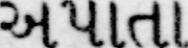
અપાતા
